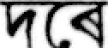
দৰে
